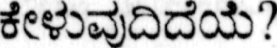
ಕೇಳುವುದಿದೆಯೆ?
